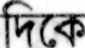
দিকে
